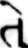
તે
